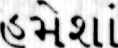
હમેશાં
